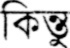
কিন্তু
